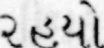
રહયો
